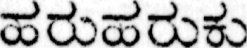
ಹರುಹರುಕು
